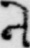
ને
